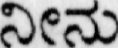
ನೀನು
